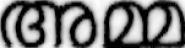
അമ്മ
